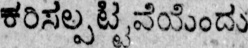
ಕರಿಸಲ್ಪಟ್ಟಿವೆಯೆಂದು
